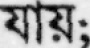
যায়;
